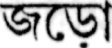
জড়ো
